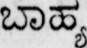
ಬಾಹ್ಯ
